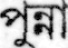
পুন্না
